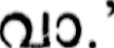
വാ.’
